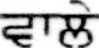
ਵਾਲੇ
